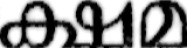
ക്ഷമ
